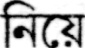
নিয়ে
